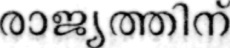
രാജ്യത്തിന്
